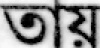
তায়
